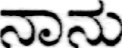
ನಾನು
